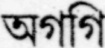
অগগি
